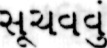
સૂચવવું
